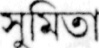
সুমিতা
